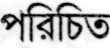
পরিচিত
